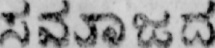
ಸಮಾಜದ
